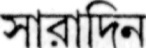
সারাদিন
